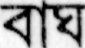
বাঘ
